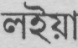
লইয়া
